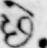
છે.
